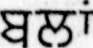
ਬਲਾਂ
